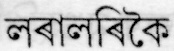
লৰালৰিকৈ
